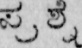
ಪ್ರಶ್ನೆ
